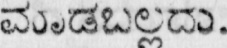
ಮಾಡಬಲ್ಲದು.
